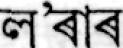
ল'ৰাৰ
